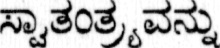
ಸ್ವಾತಂತ್ರ್ಯವನ್ನು
